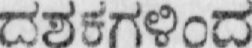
ದಶಕಗಳಿಂದ
